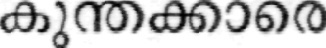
കുന്തക്കാരെ
